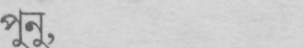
পুনু,
